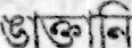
ঙাক্তনি
